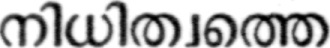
നിധിത്വത്തെ
